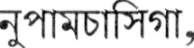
নুপামচাসিগা,
